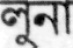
লুনা
